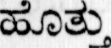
ಹೊತ್ತು
